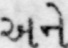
અને
